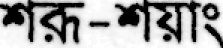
শরূ-শয়াং
